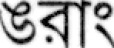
ঙরাং
